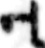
ન
